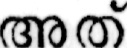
അത്
